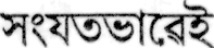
সংযতভাৱেই
